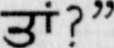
ਤਾਂ?''
